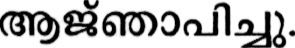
ആജ്ഞാപിച്ചു.
